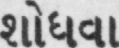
શોધવા
